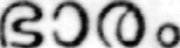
ഭാരം
